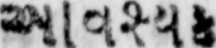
આવશ્યક
